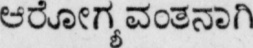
ಆರೋಗ್ಯವಂತನಾಗಿ
